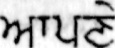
ਆਪਣੇ
